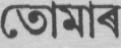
তোমাৰ
